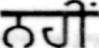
ਨਹੀਂ
